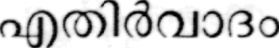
എതിര്‍വാദം
